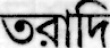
তরাদি
